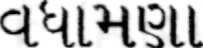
વધામણા
